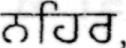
ਨਹਿਰ,
